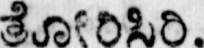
ತೋರಿಸಿರಿ.
